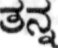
ತನ್ನ
